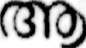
ആ
